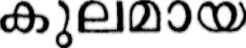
കുലമായ
